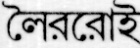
লৈররোই
